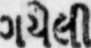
ગયેલી
